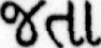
જતા
